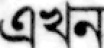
এখন
